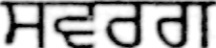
ਸਵਰਗ
